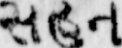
સહન
